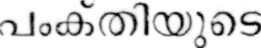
പംക്തിയുടെ
